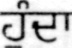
ਹੁੰਦਾ
